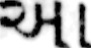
આ
